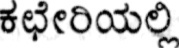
ಕಛೇರಿಯಲ್ಲಿ
